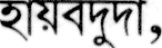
হায়বদুদা,
